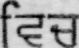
ਵਿਚ
